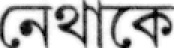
নেথাকে
